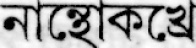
নান্থোকখ্রে
